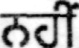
ਨਹੀਂ
